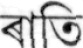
ৰাতি
